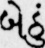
બેઠું
